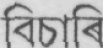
বিচাৰি
